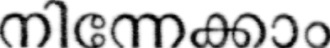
നിന്നേക്കാം
